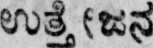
ಉತ್ತೇಜನ
